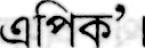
এপিক’।
